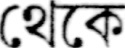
থেকে
